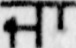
ਜਾ
